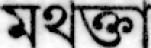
মথক্তা
